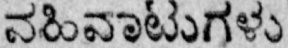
ವಹಿವಾಟುಗಳು
